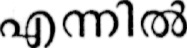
എന്നില്‍
